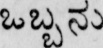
ಒಬ್ಬನು
